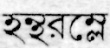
হন্থরম্লে
